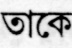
তাকে
